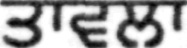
ਤਾਵਲਾ
